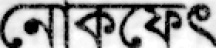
নোকফেৎ
